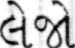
લેજો
